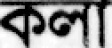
কলা
